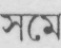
সমে
